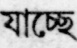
যাচ্ছে
